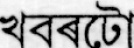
খবৰটো
